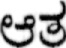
ಆತ
